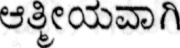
ಆತ್ಮೀಯವಾಗಿ
